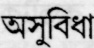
অসুবিধা
